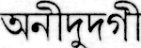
অনীদুদগী
